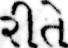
રીતે
